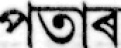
পতাৰ
